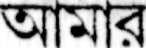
আমার
